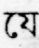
যে
